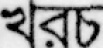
খরচ
